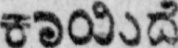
ಕಾಯಿದೆ
